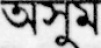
অসুম
